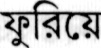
ফুরিয়ে
